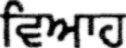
ਵਿਆਹ
